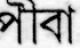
পীবা
